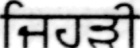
ਜਿਹੜੀ
